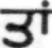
ਤਾਂ
